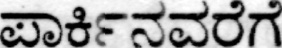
ಪಾರ್ಕಿನವರೆಗೆ
